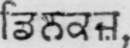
ਡਿਨਕਜ਼,
